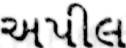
અપીલ
